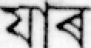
যাৰ
